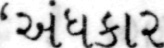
'અંધકાર
